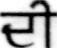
ਦੀ
